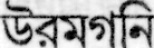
উরমগনি
